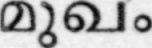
മുഖം
